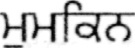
ਮੁਮਕਿਨ
